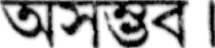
অসম্ভব।
